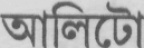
আলিটো
